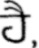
ਹੈ,
